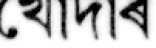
খোদাৰ
